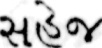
સહેજ
